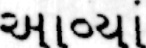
આવ્યાં
